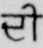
ਦੀ
